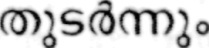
തുടര്‍ന്നും
